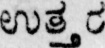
ಉತ್ತರ
